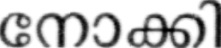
നോക്കി
